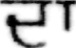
ਦਾ
